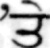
'ਤੇ
